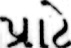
પ્રાટે
